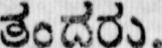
ತಂದರು.
